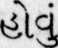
હોવું
